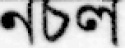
নচল
